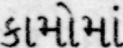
કામોમાં
